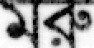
মরু
